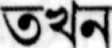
তখন
